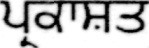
ਪ੍ਰਕਾਸ਼ਤ
